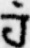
ਹੋ
